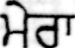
ਮੇਰਾ
